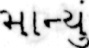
માન્યું
